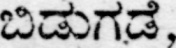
ಬಿಡುಗಡೆ,
